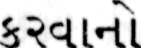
કરવાનો
